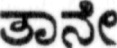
ತಾನೇ
